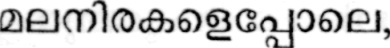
മലനിരകളെപ്പോലെ,
